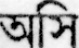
অসি
